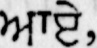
ਆਏ,
